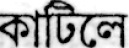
কাটিলে
